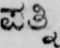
ಪತ್ನಿ
